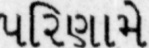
પરિણામે
